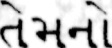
તેમનો
